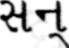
સન્
